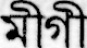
মীগী
